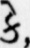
કે,
